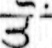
ਤੋਂ
